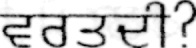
ਵਰਤਦੀ?
